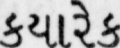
કયારેક
